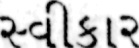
સ્વીકાર
